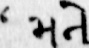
'મને
